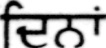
ਦਿਨਾਂ
